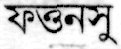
ফত্তনসু
